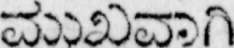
ಮುಖವಾಗಿ
